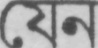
যেন
